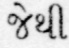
જેથી
